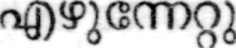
എഴുന്നേറ്റു
